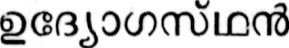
ഉദ്യോഗസ്ഥന്‍
